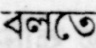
বলতে
